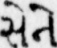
સેને
